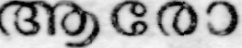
ആരോ
